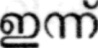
ഇന്ന്
